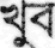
খুব
